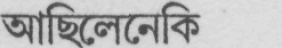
আছিলেনেকি
